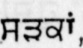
ਸੜਕਾਂ,
